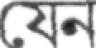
যেন
